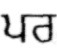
ਪਰ
